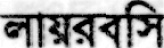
লায়রবসি
